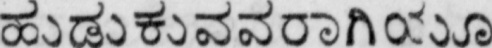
ಹುಡುಕುವವರಾಗಿಯೂ
